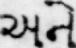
અને
